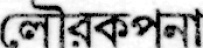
লৌরকপনা
